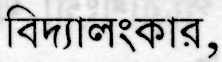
বিদ্যালংকার,
